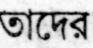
তাদের
